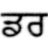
ਡਰ
